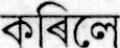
কৰিলে
